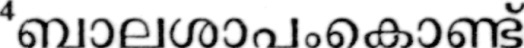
4ബാലശാപംകൊണ്ട്
